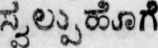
ಸ್ವಲ್ಪುಹೊಗೆ
